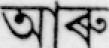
আৰু
